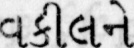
વકીલને
